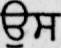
ਉਸ
